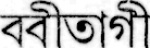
ববীতাগী
